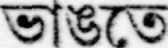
ভাঙতে
